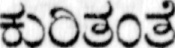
ಕುರಿತಂತೆ
